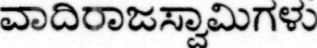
ವಾದಿರಾಜಸ್ವಾಮಿಗಳು
